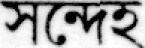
সন্দেহ
